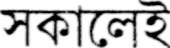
সকালেই
